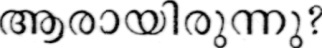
ആരായിരുന്നു?
